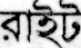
রাইট
